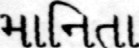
માનિતા
